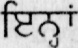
ਇਨ੍ਹਾਂ
